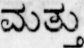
ಮತ್ತು
